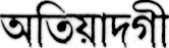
অতিয়াদগী
